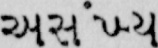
અસંખ્ય
